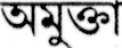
অমুক্তা
